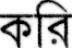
করি
